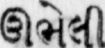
ઊભેલી
